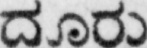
ದೂರು
